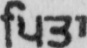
ਪਿਤਾ
